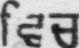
ਵਿਚ
